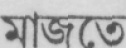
মাজতে
